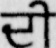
ਦੀ
